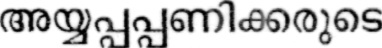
അയ്യപ്പപ്പണിക്കരുടെ
